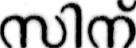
സിന്
